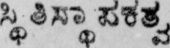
ಸ್ಥಿತಿಸ್ಥಾಪಕತ್ವ
